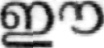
ഈ
